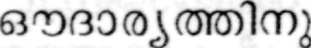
ഔദാര്യത്തിനു
